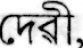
দেৱী,
